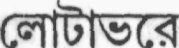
লোটাভরে
